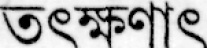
তৎক্ষণাৎ
